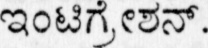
ಇಂಟಿಗ್ರೇಶನ್.
